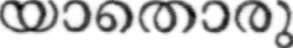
യാതൊരു
